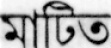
মাটিত
